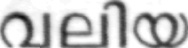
വലിയ
